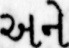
અને
